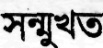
সন্মুখত
